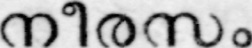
നീരസം
